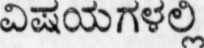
ವಿಷಯಗಳಲ್ಲಿ
